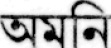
অমনি
